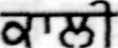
ਕਾਲੀ
